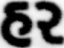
હર
